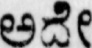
ಅದೇ
